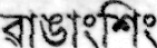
ৱাঙাংশিং
